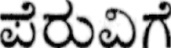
ಪೆರುವಿಗೆ
